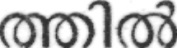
ത്തില്‍
